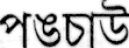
পঙচাউ
